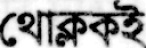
থোক্লকই
